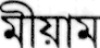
মীয়াম
